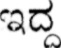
ಇದ್ದ
